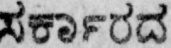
ಸರ್ಕಾರದ
